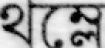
থম্লে
